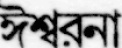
ঈশ্বরনা
